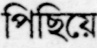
পিছিয়ে
